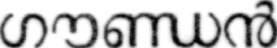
ഗൗണ്ഡന്‍
